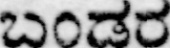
ಬಂಡರ
